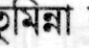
তুমিন্না
